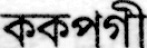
ককপগী
